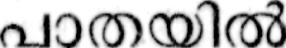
പാതയില്‍
